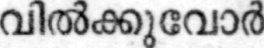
വില്‍ക്കുവോര്‍
